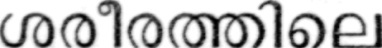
ശരീരത്തിലെ
